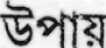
উপায়
